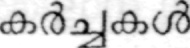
കര്‍ച്ചകള്‍
